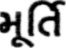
મૂર્તિ
